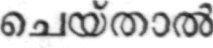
ചെയ്താല്‍
